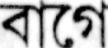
বাগে
